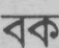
বক
